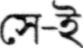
সে-ই
